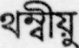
থম্বীয়ু
